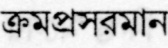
ক্রমপ্রসরমান
